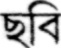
ছবি
